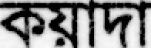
কয়াদা
